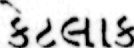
કેટલાક
